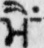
ਮੈਂ
